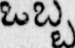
ಒಬ್ಬ
